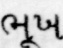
ભૂખ
